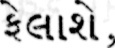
ફેલાશે,
